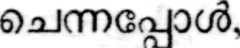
ചെന്നപ്പോള്‍,
